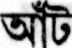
আঁট
